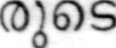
രുടെ
